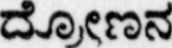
ದ್ರೋಣನ
